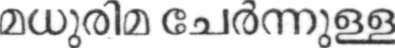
മധുരിമചേര്‍ന്നുള്ള
